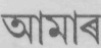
আমাৰ
